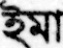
ইমা
